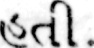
હતી.
